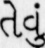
તેવું
